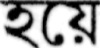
হয়ে
